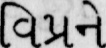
વિપ્રને
